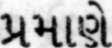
પ્રમાણે
